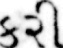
કરી
